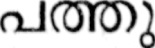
പത്തു
